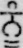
ਨੂੰ
